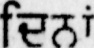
ਦਿਨਾਂ
